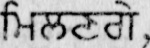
ਮਿਲਣਗੇ,
